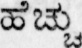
ಹೆಚ್ಚು
